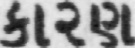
કારણ
